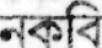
নকবি
